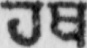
ਹਥ
